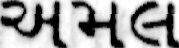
અમલ
